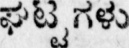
ಘಟ್ಟಗಳು
